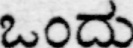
ಒಂದು
